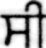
ਸੀ
